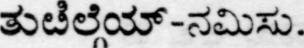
ತುೞೆಲ್ಗೆಯ್-ನಮಿಸು,
